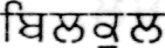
ਬਿਲਕੁਲ
